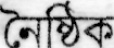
নৈষ্ঠিক
